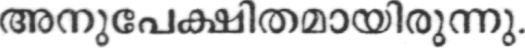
അനുപേക്ഷിതമായിരുന്നു.
